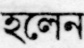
হলেন
